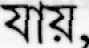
যায়,
